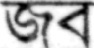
জব
